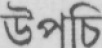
উপচি
